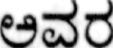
ಅವರ
